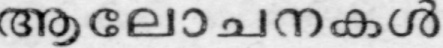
ആലോചനകള്‍
